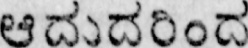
ಆದುದರಿಂದ
